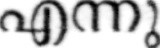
എന്നു
